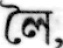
লৈ,
